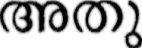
അതു
